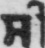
ਸੀ
